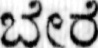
ಬೇರೆ
